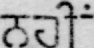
ਨਹੀਂ
